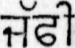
ਜੱਫੀ
